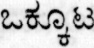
ಒಕ್ಕೂಟ
